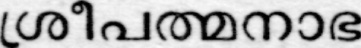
ശ്രീപത്മനാഭ
